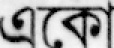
একো
